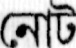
নোট
